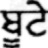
ਬੂਟੇ
